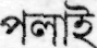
পলাই
